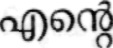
എന്റെ
